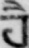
ਹੈ
